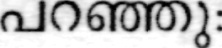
പറഞ്ഞു:
